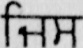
ਜਿਸ
